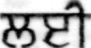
ਲਈ
